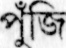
পুঁজি
